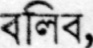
বলিব,
